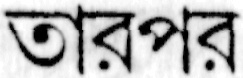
তারপর
